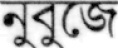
নুবুজে
